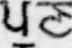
ਪੁਣ
